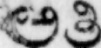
ಅತಿ
